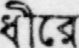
ধীরে
